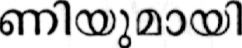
ണിയുമായി
